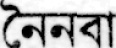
নৈনবা
